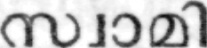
സ്വാമി
